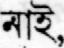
নাই,
